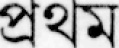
প্রথম
